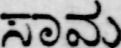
ಸಾಮ
